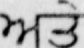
ਅਤੇ
